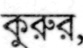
কুরুর,
